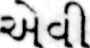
એવી
